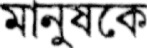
মানুষকে
